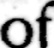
of
